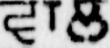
ਵਾਲ
